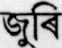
জুৰি
